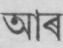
আৰ
